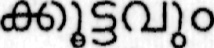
ക്കൂട്ടവും
